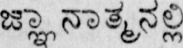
ಜ್ಞಾನಾತ್ಮನಲ್ಲಿ
